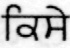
ਕਿਸੇ
